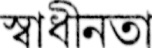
স্বাধীনতা
